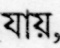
যায়,
